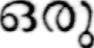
ഒരു
